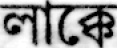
লাক্কে
